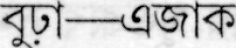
বুঢ়া-এজাক
